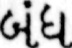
બંધ
